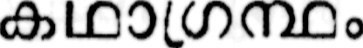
കഥാഗ്രന്ഥം
